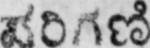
ಪರಿಗಣಿ
